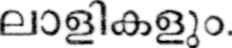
ലാളികളും.
